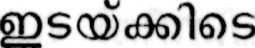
ഇടയ്ക്കിടെ
